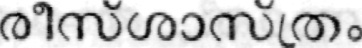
രീസ്ശാസ്ത്രം
